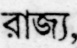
রাজ্য,
